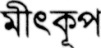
মীৎকূপ
